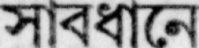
সাবধানে
